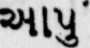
આપું
